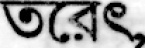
তরেৎ,
